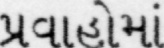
પ્રવાહોમાં
